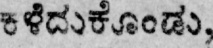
ಕಳೆದುಕೊಂಡು,
